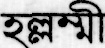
হল্লম্মী
